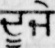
ਦੂਜੇ
